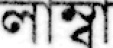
লাম্বা
